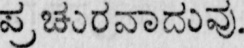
ಪ್ರಚುರವಾದುವು.
